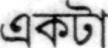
একটা
